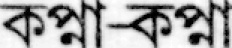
কপ্না-কপ্না
